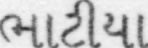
ભાટીયા
